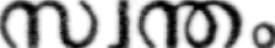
സ്വന്തം
